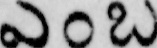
ಎಂಬ
